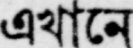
এখানে
